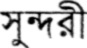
সুন্দরী
